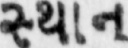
સ્થાન
